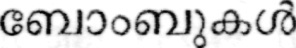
ബോംബുകള്‍
